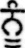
ਨੂੰ
